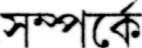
সম্পর্কে
